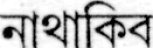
নাথাকিব
